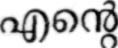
എന്റെ
